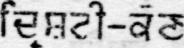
ਦ੍ਰਿਸ਼ਟੀ-ਕੋਣ
